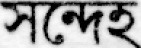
সন্দেহ
